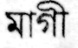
মাগী
